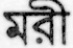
মরী
